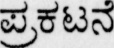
ಪ್ರಕಟಣೆ
